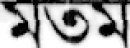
মতম
